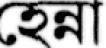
হেন্না
